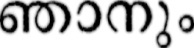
ഞാനും
